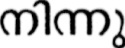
നിന്നു
